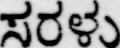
ಸರಳು
